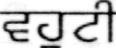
ਵਹੁਟੀ
